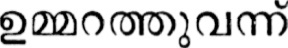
ഉമ്മറത്തുവന്ന്
